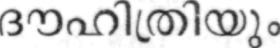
ദൌഹിത്രിയും
